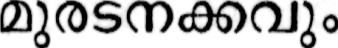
മുരടനക്കവും
